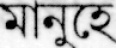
মানুহে
